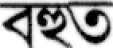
বহুত
